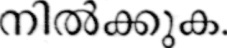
നില്‍ക്കുക.
